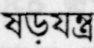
ষড়যন্ত্র
